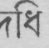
দধি
